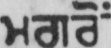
ਮਗਰੋਂ
